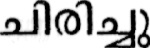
ചിരിച്ചു
